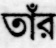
তাঁর
